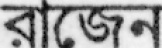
রাজেন
